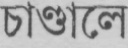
চাণ্ডালে
